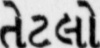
તેટલો
